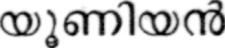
യൂണിയന്‍
